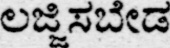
ಲಜ್ಜಿಸಬೇಡ
